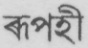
ৰূপহী
